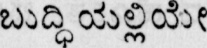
ಬುದ್ಧಿಯಲ್ಲಿಯೇ
